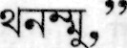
থনম্মু,”
